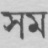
সম
